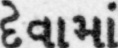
દેવામાં
